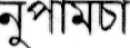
নুপামচা
